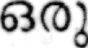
ഒരു
